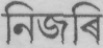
নিজৰি
